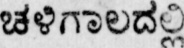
ಚಳಿಗಾಲದಲ್ಲಿ
